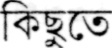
কিছুতে
